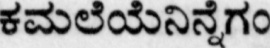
ಕಮಲೆಯೆನಿನ್ನೆಗಂ
